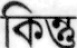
কিন্তু
